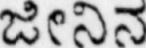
ಜೀನಿನ
